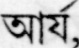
আর্য,
